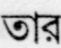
তার
